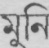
মুনি
